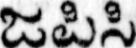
ಜಪಿಸಿ
